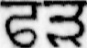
ਫੜ
